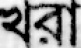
খরা
